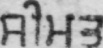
ਸੀਮਤ
